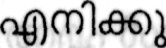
എനിക്കു
